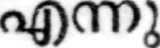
എന്നു
